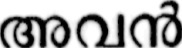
അവന്‍
